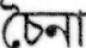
চৈনা
